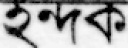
হন্দক
